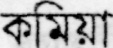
কমিয়া
